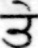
ਤੇ
